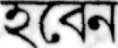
হবেন
